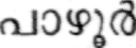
പാഴൂര്‍
